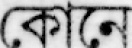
কোনে
